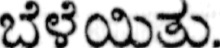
ಬೆಳೆಯಿತು.
